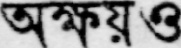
অক্ষয়ও
